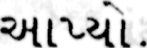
આપ્યો.
